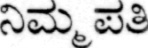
ನಿಮ್ಮಪತಿ
